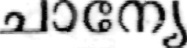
ചാന്യേ
